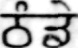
ਠੰਡੇ
